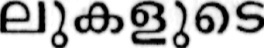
ലുകളുടെ
